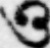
ও
